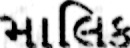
માલિક
